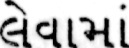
લેવામાં
